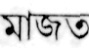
মাজত
